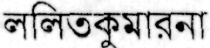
ললিতকুমারনা
